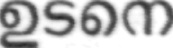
ഉടനെ
